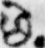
છે.
